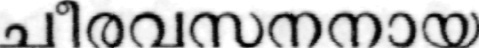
ചീരവസനനായ
